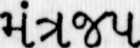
મંત્રજાપ
